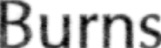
Burns
